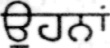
ਉਹਨਾਂ
